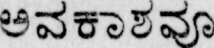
ಅವಕಾಶವೂ
